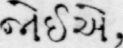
જોઈએ,
